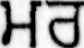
ਮਰ
